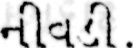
નીવડી.
